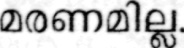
മരണമില്ല.
